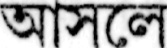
আসলে
